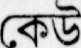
কেউ
